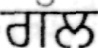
ਗੱਲ
